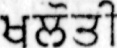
ਖਲੋਤੀ
